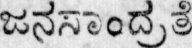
ಜನಸಾಂದ್ರತೆ
